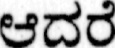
ಆದರೆ
